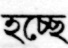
হচ্ছে
